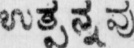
ಉತ್ಪನ್ನವು
